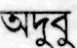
অদুবু
